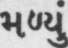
મળ્યું
